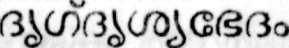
ദൃഗ്ദൃശ്യഭേദം
